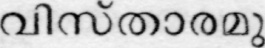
വിസ്താരമു
